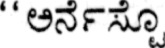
"ಅರ್ನೆಸ್ಟೊ
